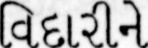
વિદારીને
